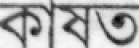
কাষত
